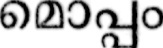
മൊപ്പം
